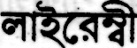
লাইরেম্বী
